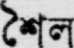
শৈল
